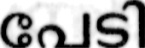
പേടി
